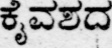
ಕೈವಶದ
